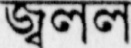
জ্বলল
